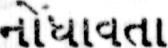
નોંધાવતા
